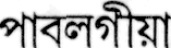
পাবলগীয়া
